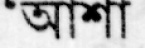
“আশা
